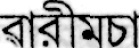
ৱারীমচা
